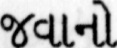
જવાનો
